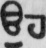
ਉਹ
